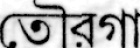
তৌরগা
